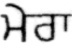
ਮੇਰਾ
